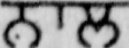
ਨਾਲ
